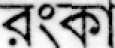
রংকা
